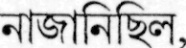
নাজানিছিল,
